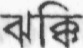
ঝক্কি
